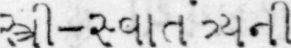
સ્ત્રી-સ્વતંત્ર્યની
